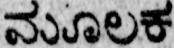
ಮೂಲಕ
